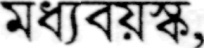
মধ্যবয়স্ক,
